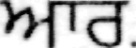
ਆਰ.
